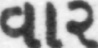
વાર
